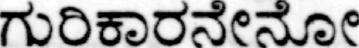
ಗುರಿಕಾರನೇನೋ
